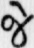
જે"
